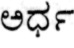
ಅರ್ಧ
